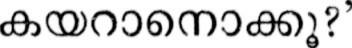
കയറാനൊക്കൂ?'
